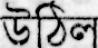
উঠিল
